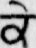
ਕੇ
